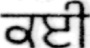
ਕਈ
